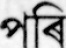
পৰি
